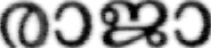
രാജാ
